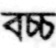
বচ্চ
